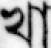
খা
